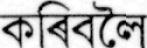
কৰিবলৈ
